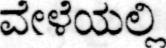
ವೇಳೆಯಲ್ಲಿ
